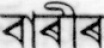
বাৰীৰ
